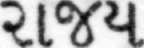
રાજ્ય
